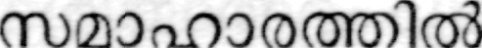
സമാഹാരത്തില്‍
